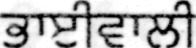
ਭਾਈਵਾਲੀ
